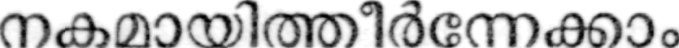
നകമായിത്തീര്‍ന്നേക്കാം
